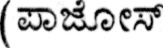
(ಪಾಜೋಸ್
